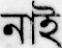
নাই
